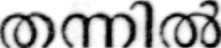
തന്നില്‍
